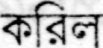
করিল
